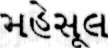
મહેસૂલ
